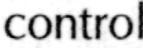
control
